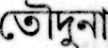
তৌদুনা
